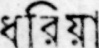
ধরিয়া
